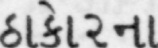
ઠાકોરના
